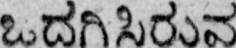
ಒದಗಿಸಿರುವ
